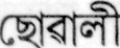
ছোৱালী
